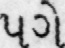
પગે
